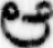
ಆ
